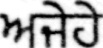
ਅਜੇਹੇ
